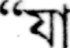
“যা
